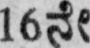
16ನೇ
